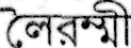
লৈরম্মী
